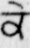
ਕੇ
